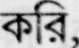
করি,
